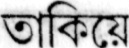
তাকিয়ে
